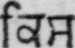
ਕਿਸ
